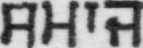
ਸਮਾਜ
